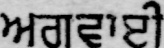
ਅਗਵਾਈ
